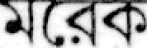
মরেক
